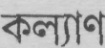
কল্যাণ
